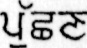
ਪੁੱਛਣ
